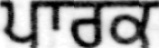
ਪਾਰਕ
